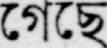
গেছে
